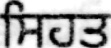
ਸਿਹਤ
